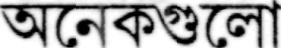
অনেকগুলো
